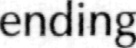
ending
